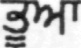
ਭੂਆ
